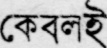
কেবলই
